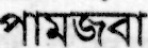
পামজবা
